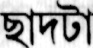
ছাদটা
